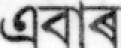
এবাৰ
